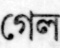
গেল
